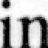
in
